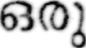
ഒരു
